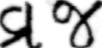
વ્રજ
